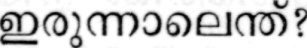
ഇരുന്നാലെന്ത്?
